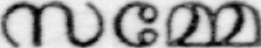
സമ്മേ
